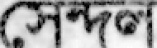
সেন্দল
